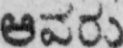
ಅವರು
